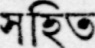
সহিত
